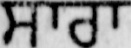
ਸਾਰਾ
